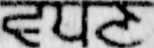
ਵਧਣ
